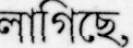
লাগিছে,
